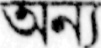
অন্য
